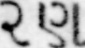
રણ
